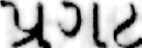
પ્રગટ
